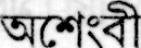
অশেংবা
